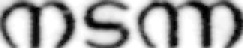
നടന്ന
